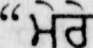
''ਮੇਰੇ
